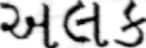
અલક
